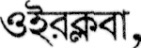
ওইরক্লবা,
